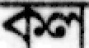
কল
